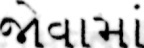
જોવામાં
